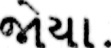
જોયા.
